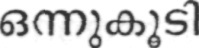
ഒന്നുകൂടി
